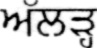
ਅੱਲੜ੍ਹ
